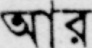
আর
